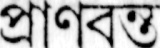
প্রাণবন্ত
